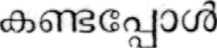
കണ്ടപ്പോള്‍
